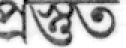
প্রস্তুত
